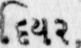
દિયર,
